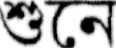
শুনে
